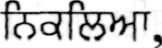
ਨਿਕਲਿਆ,
